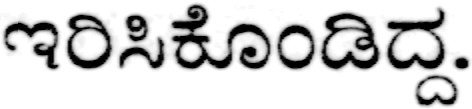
ಇರಿಸಿಕೊಂಡಿದ್ದ.
